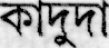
কাদুদা
